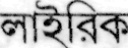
লাইরিক
